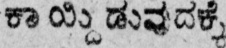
ಕಾಯ್ದಿಡುವುದಕ್ಕೆ
